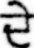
ਦੇ
